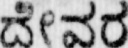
ದೇವರ
